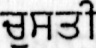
ਚੁਸਤੀ
